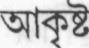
আকৃষ্ট
